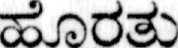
ಹೊರತು
